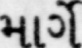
માર્ગે
